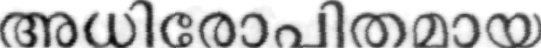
അധിരോപിതമായ
